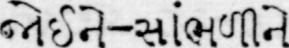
જોઈને-સાંભળીને
